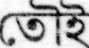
তৌই
